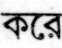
করে
